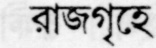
রাজগৃহে
